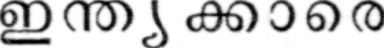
ഇന്ത്യക്കാരെ
